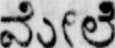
ಮೇಲೆ
